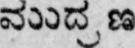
ಮುದ್ರಣ
